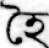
হৈ
